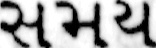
સમય
